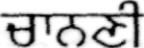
ਚਾਨਣੀ
